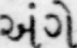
અંગે
